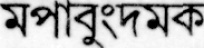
মপাবুংদমক
